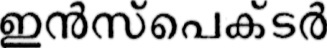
ഇന്‍സ്പെക്ടര്‍
